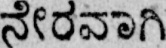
ನೇರವಾಗಿ
